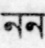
নন
